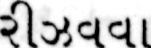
રીઝવવા
